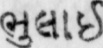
ભુલાઈ
